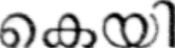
കെയി
